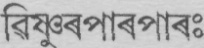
ৱিষ্ণুৰপাৰপাৰঃ
